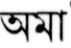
অমা
